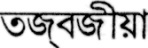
তজ্‌বজীয়া
